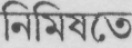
নিমিষতে
